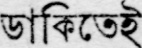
ডাকিতেই
